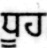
ਧੂਹ
